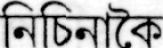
নিচিনাকৈ
